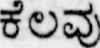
ಕೆಲವು
